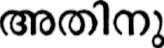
അതിനു
